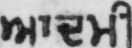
ਆਦਮੀ
